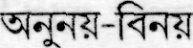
অনুনয়-বিনয়
